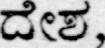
ದೇಶ,
